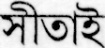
সীতাই
